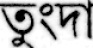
তুংদা
